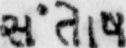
સંતોષ
